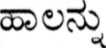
ಹಾಲನ್ನು
